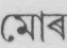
মোৰ
